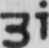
ਤਾਂ
